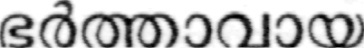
ഭര്‍ത്താവായ
